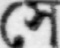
সে
